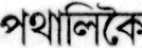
পথালিকৈ
